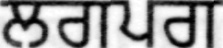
ਲਗਪਗ
